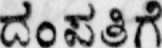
ದಂಪತಿಗೆ
